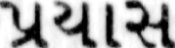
પ્રયાસ
